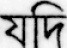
যদি
